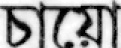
চায়ো
